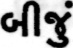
બીજું
